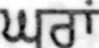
ਘਰਾਂ
